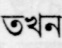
তখন
